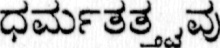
ಧರ್ಮತತ್ತ್ವವು
